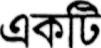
একটি
